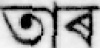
তাৰ
